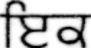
ਇਕ
